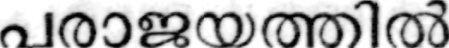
പരാജയത്തില്‍
